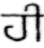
ਹੀ
